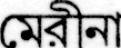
মেরীনা
